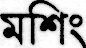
মশিং
